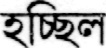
হচ্ছিল
